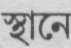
স্থানে
